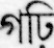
গঢ়ি
